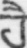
ਹੈ
